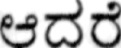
ಆದರೆ
